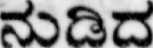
ನುಡಿದ
